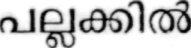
പല്ലക്കില്‍
